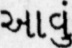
આવું
